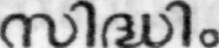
സിദ്ധിം
